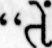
"તેં
